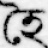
হৈ
